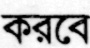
করবে
